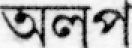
অলপ
